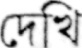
দেখি
